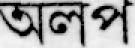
অলপ
